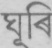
ঘূৰি
